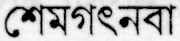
শেমগৎনবা
